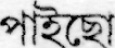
পাইছো
